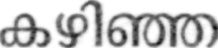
കഴിഞ്ഞ
